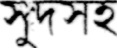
সুদসহ
